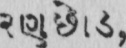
રણછોડ,
